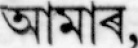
আমাৰ,
